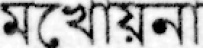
মখোয়না
